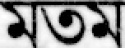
মতম
